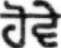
ਹੋਵੇ
